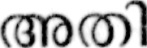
അതി
